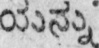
ಯನ್ನು
